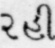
રહી
